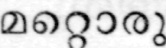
മറ്റൊരു
